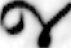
જ
